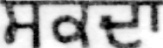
ਸਕਦਾ
